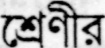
শ্রেণীর
